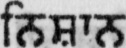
ਨਿਸ਼ਾਨ
